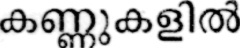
കണ്ണുകളില്‍
